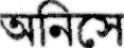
অনিসে
